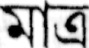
মাত্র
